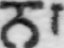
ਨਾ
